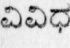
ವಿವಿಧ
